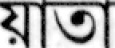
য়াতা
